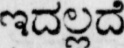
ಇದಲ್ಲದೆ
